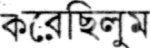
করেছিলুম
